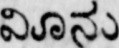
ಮೀನು
